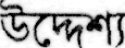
উদ্দেশ
